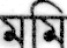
মমি
